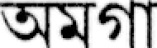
অমগা
